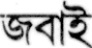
জবাই
